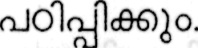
പഠിപ്പിക്കും.
